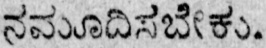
ನಮೂದಿಸಬೇಕು.
